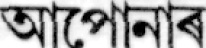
আপোনাৰ
